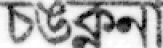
চঙক্ননা
